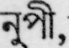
নুপী,
